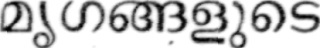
മൃഗങ്ങളുടെ
